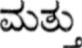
ಮತ್ತು
